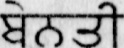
ਬੇਨਤੀ
